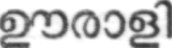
ഊരാളി
